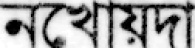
নখোয়দা
